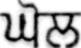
ਘੋਲ
